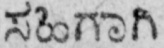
ಸಹಿಗಾಗಿ
